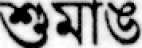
শুমাঙ
